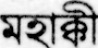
মহাক্কী
